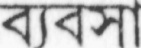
ব্যবসা
